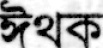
ঈথক
